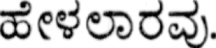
ಹೇಳಲಾರವು.
